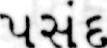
પસંદ
